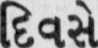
દિવસે
